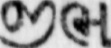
જીભ
